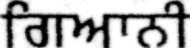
ਗਿਆਨੀ
